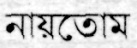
নায়তোম
